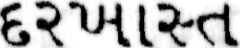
દરખાસ્ત
